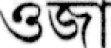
ওজা
